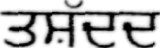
ਤਸ਼ੱਦਦ
